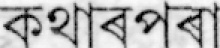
কথাৰপৰা
